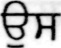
ਉਸ
